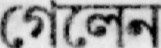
গেলেন
